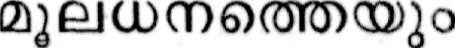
മൂലധനത്തെയും
